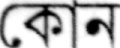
কোন
